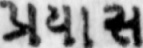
પ્રયાસ
